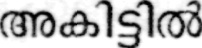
അകിട്ടില്‍
